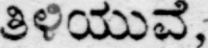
ತಿಳಿಯುವೆ,
